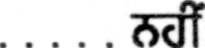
.....ਨਹੀਂ
